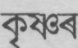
কৃষ্ণৰ
